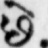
છે.
